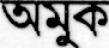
অমুক
